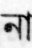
না
